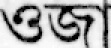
ওজা
